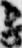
કે
